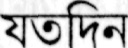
যতদিন
